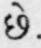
છે.
